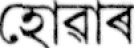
হোৱাৰ
